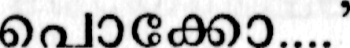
പൊക്കോ....'
